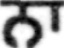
ਨਾ
